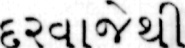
દરવાજેથી
